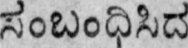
ಸಂಬಂಧಿಸಿದ
